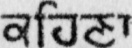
ਕਹਿਣਾ
